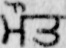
ਮੌਤ
